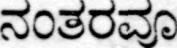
ನಂತರವೂ
